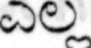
ಎಲ್ಲ
